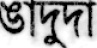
ঙাদুদা
